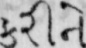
કરીને
